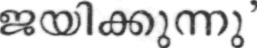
ജയിക്കുന്നു'
